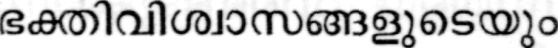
ഭക്തിവിശ്വാസങ്ങളുടെയും
